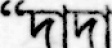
“দাদা
